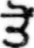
ਤੋਂ
